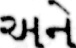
અને
